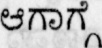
ಆಗಾಗ್ಗೆ
